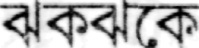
ঝকঝকে
